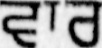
ਵਾਰ
